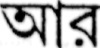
আর
